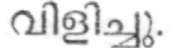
വിളിച്ചു.
